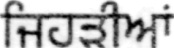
ਜਿਹੜੀਆਂ
